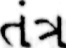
તંત્ર
